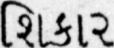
શિકાર
